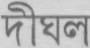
দীঘল
